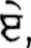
ਏ,
